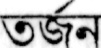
তর্জন
